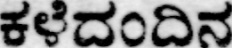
ಕಳೆದ೦ದಿನ
